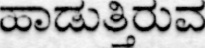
ಹಾಡುತ್ತಿರುವ
